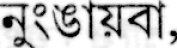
নুংঙায়বা,
